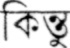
কিন্তু
